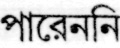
পারেননি
